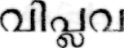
വിപ്ലവ
